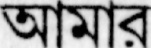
আমার
